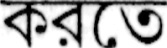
করতে
